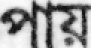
পায়
